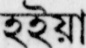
হইয়া
